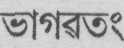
ভাগৱতং
